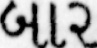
બાર
